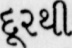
દૂરથી
